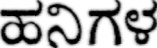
ಹನಿಗಳ
